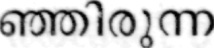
ഞ്ഞിരുന്ന
